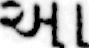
આ
